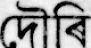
দৌৰি
